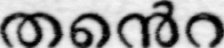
തന്റെ
